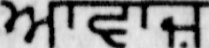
ਆਵਾਜ਼
